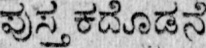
ಪುಸ್ತಕದೊಡನೆ
